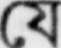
যে
